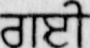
ਗਈ
